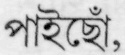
পাইছোঁ,
